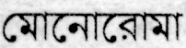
মোনোমোমা
